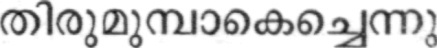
തിരുമുമ്പാകെച്ചെന്നു
